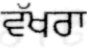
ਵੱਖਰਾ
